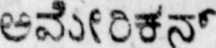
ಅಮೇರಿಕನ್
